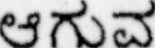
ಆಗುವ
